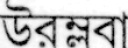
উরম্লবা
